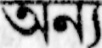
অন্য
